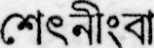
শেৎনীংবা
